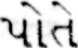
પોતે
